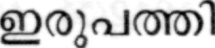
ഇരുപത്തി
